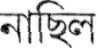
নাছিল
